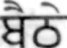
ਬੈਠੇ
